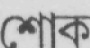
শোক
